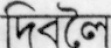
দিবলৈ
